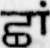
ਛਾਂ
